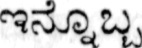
ಇನ್ನೊಬ್ಬ
